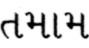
તમામ
